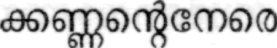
ക്കണ്ണന്റെനേരെ
